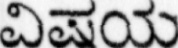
ವಿಷಯ
